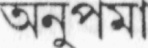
অনুপমা
